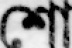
শো
